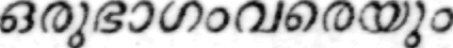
ഒരുഭാഗംവരെയും
